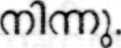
നിന്നു.
